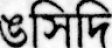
ঙসিদি
